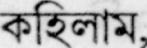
কহিলাম,
